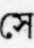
সে
